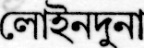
লোইনদুনা
